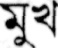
মুখ
